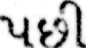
પછી
